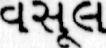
વસૂલ
